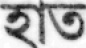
হাত
